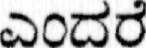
ಎಂದರೆ
